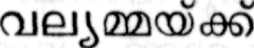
വല്യമ്മയ്ക്ക്
